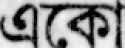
একো
